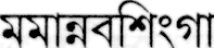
মমান্নবশিংগা
